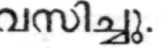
വസിച്ചു.
